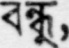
বন্ধু,
